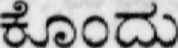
ಕೊಂದು
